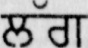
ਲੱਗ
